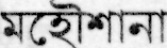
মহৌশানা
